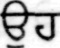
ਉਹ
